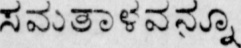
ಸಮತಾಳವನ್ನೂ
